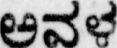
ಅವಳ
